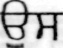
ਉਸ
